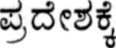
ಪ್ರದೇಶಕ್ಕೆ
